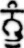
ਨੂੰ
